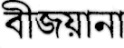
বীজয়ানা
